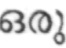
ഒരു
